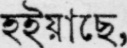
হইয়াছে,
